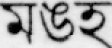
মঙহ
